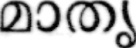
മാതൃ
